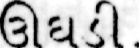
ઊઘડી.
